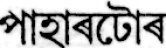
পাহাৰটোৰ
